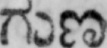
ಗುಣ
